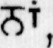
ਨਾਂ,
